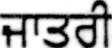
ਜਾਤਰੀ
